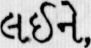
લઈને,
